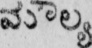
ಮೌಲ್ಯ
